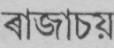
ৰাজাচয়
